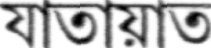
যাতায়াত
